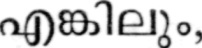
എങ്കിലും,
